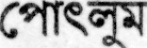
পোৎলুম
